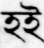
হই
